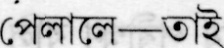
পেলালে-তাই
